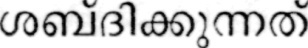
ശബ്ദിക്കുന്നത്
